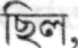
ছিল,
